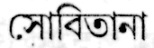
সোবিতানা
